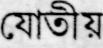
যোতীয়
